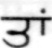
ਤਾਂ
